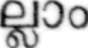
ല്ലാം
